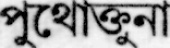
পুথোক্তুনা
